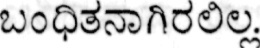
ಬಂಧಿತನಾಗಿರಲಿಲ್ಲ.
